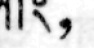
লাং,
